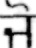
ਜੋ
